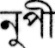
নুপী
